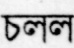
চলল
